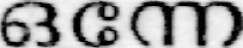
ഒന്നേ
